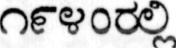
೧೯೪೦ರಲ್ಲಿ
